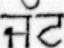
ਜੱਟ
